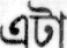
এটা
